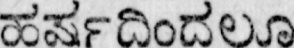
ಹರ್ಷದಿಂದಲೂ
